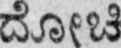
ದೋಚಿ
